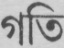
গতি
